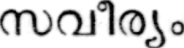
സവീര്യം
